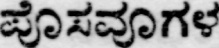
ಪೊಸವೂಗಳ
